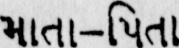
માતા-પિતા
